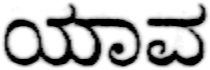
ಯಾವ
